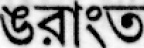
ঙরাংত
